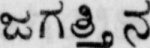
ಜಗತ್ತಿನ
